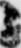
કે
